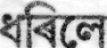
ধৰিলে
